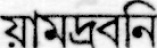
য়ামদ্রবনি
